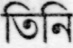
তিনি
